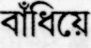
বাঁধিয়ে
